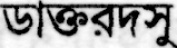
ডাক্তরদসু
